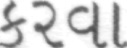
કરવા
